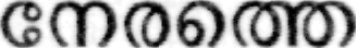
നേരത്തെ
